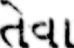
તેવા
